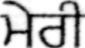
ਮੇਰੀ
